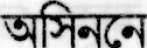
অসিননে
